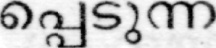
പ്പെടുന്ന
